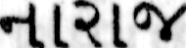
નારાજ
